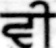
ਵੀ
